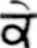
ਕੇ
